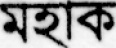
মহাক
